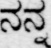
ನನ್ನ
